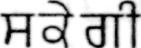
ਸਕੇਗੀ
